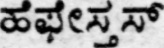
ಹಫೇಸ್ತಸ್
